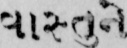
વાસ્તુને
